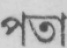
পতা
